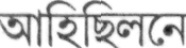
আহিছিলনে
